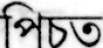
পিচত
